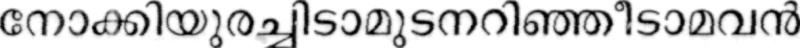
നോക്കിയുരച്ചിടാമുടനറിഞ്ഞീടാമവന്‍
